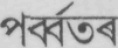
পৰ্ব্বতৰ
